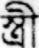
স্ত্রী
